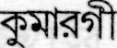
কুমারগী
